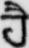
ਹੈ
